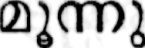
മൂന്നു
